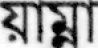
য়াম্না
